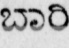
ಬಾರಿ
